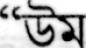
“উম
